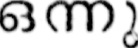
ഒന്നു
